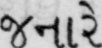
જનારે
